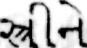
મારી
